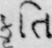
કૃતિ
